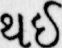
થઈ
